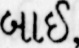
બાઈ,
